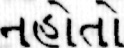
નહોતો
